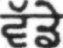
ਵੱਡੇ
